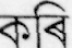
কৰি
